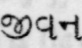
જીવન
